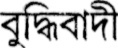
বুদ্ধিবাদী
